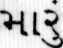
મારું
